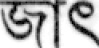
জাৎ
